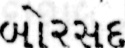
બોરસદ
